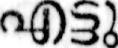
എട്ടു
